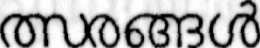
ത്സരങ്ങള്‍
